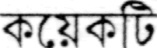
কয়েকটি
